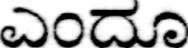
ಎಂದೂ
